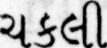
ચકલી
